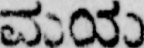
ಮಯ
